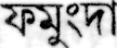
ফমুংদা
